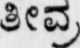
ತೀವ್ರ
